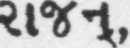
રાજન્,
